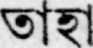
তাহা
